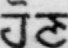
ਹੋਣ
